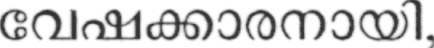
വേഷക്കാരനായി,
